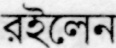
রইলেন
